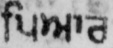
ਪਿਆਰ
